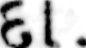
દા.
